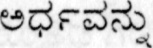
ಅರ್ಧವನ್ನು
